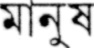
মানুষ
